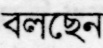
বলছেন
